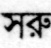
সরু
